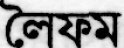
লৈফম
